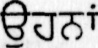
ਉਹਨਾਂ
